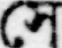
সে
